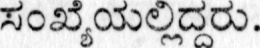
ಸಂಖ್ಯೆಯಲ್ಲಿದ್ದರು.
